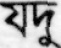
যদু
